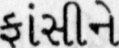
ફાંસીને
